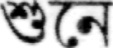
শুনে
